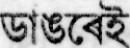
ডাঙৰেই
